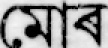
মোৰ
